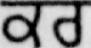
ਕਰ
